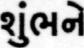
શુંભને
